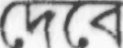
দেবে
